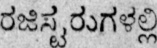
ರಜಿಸ್ಟರುಗಳಲ್ಲಿ
